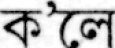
ক'লে
